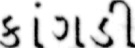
કાંગડી
